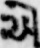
એ
